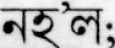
নহ'ল;
